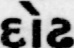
દોઢ
